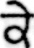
ਕੇ
